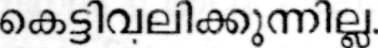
കെട്ടിവലിക്കുന്നില്ല.
